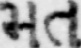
મત
